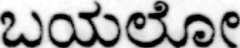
ಬಯಲೋ
